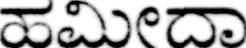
ಹಮೀದಾ
